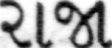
રાજા
